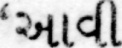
'આવી
